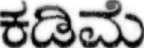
ಕಡಿಮೆ
